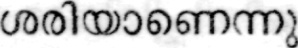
ശരിയാണെന്നു
